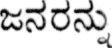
ಜನರನ್ನು
